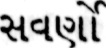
સવર્ણો
